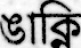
ঙাক্নি
